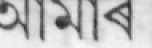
আমাৰ
